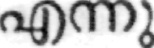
എന്നു
